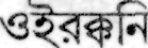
ওইরক্কনি
